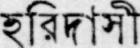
হরিদাসী
